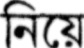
নিয়ে
